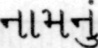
નામનું
